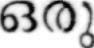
ഒരു
